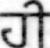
ਹੀ
